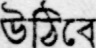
উঠিবে
